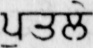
ਪੁਤਲੇ
